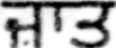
ਜ਼ਾਤ
